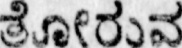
ತೋರುವ
